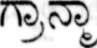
ಗ್ರಾನ್ಮಾ
